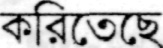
করিতেছে
